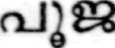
പൂജ
